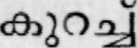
കുറച്ച്
